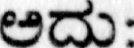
ಅದು:
